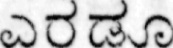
ಎರಡೂ
